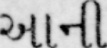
આની
